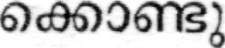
ക്കൊണ്ടു
